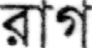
রাগ
